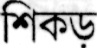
শিকড়
